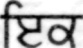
ਇਕ
